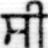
ਸੀ
